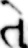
તે
